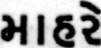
માહરે
